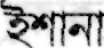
ইশানা
